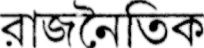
রাজনৈতিক
